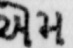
એમ
